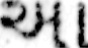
આ
